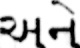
અને
